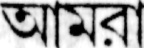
আমরা
